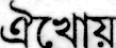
ঐখোয়
